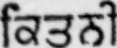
ਕਿਤਨੀ
